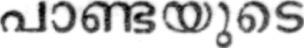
പാണ്ടയുടെ
